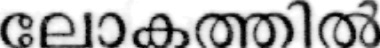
ലോകത്തില്‍
